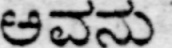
ಅವನು
